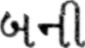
બની
